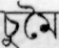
চুমৈ
